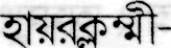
হায়রক্লম্মী-
